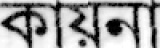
কায়না
